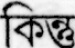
কিন্তু
